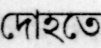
দোহতে
